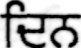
ਦਿਨ
